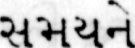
સમયને
